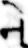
ને
